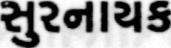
સરનાયક
